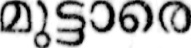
മുട്ടാരെ
